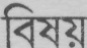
বিষয়
